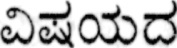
ವಿಷಯದ
